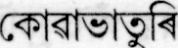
কোৱাভাতুৰি
